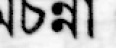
মচন্না
